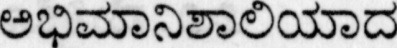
ಅಭಿಮಾನಿಶಾಲಿಯಾದ
